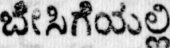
ಬೇಸಿಗೆಯಲ್ಲಿ
